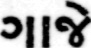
ગાજે
